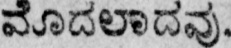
ಮೊದಲಾದವು.
